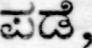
ಪಡೆ,
